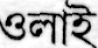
ওলাই
